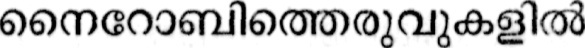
നൈറോബിത്തെരുവുകളില്‍
